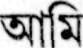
আমি
